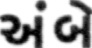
અંબે
